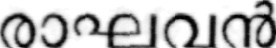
രാഘവന്‍
